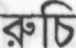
রুচি
